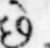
છે.
